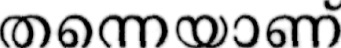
തന്നെയാണ്
